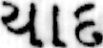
યાદ
